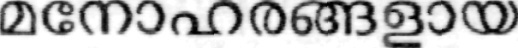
മനോഹരങ്ങളായ
